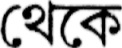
থেকে
